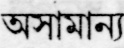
অসামান্য
